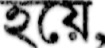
হয়ে,
